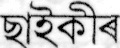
ছাইকীৰ
